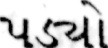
પડ્યો
